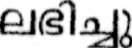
ലഭിച്ചു
